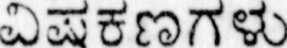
ವಿಷಕಣಗಳು
